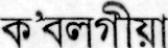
ক'বলগীয়া
